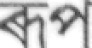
ৰূপ
